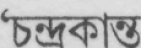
'চন্দ্ৰকান্ত
